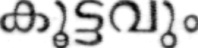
കൂട്ടവും
